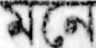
মনে
